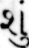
શું
